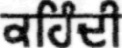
ਕਹਿੰਦੀ
